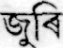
জুৰি
